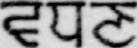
ਵਧਣ
